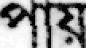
পায়
